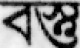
বস্তু
